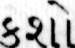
કશો
